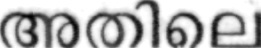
അതിലെ
